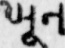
ખૂન
